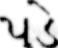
પડે
